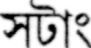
সটাং
